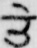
ਤੇ
